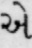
એ
